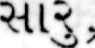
સારુ,
